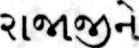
રાજાજીને
